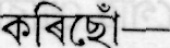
কৰিছোঁ-
